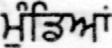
ਮੁੰਡਿਆਂ
